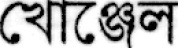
খোঞ্জেল
